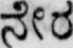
ನೇರ
